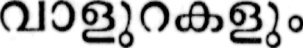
വാളുറകളും
